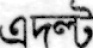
এদল্ট
